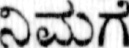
ನಿಮಗೆ
